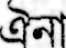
ঐনা
